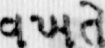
વખતે
